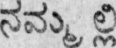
ನಮ್ಮಲ್ಲಿ
